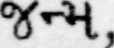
જન્મ,
